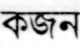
কজন
